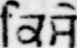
ਕਿਸੇ
